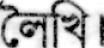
লৈখি।
